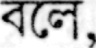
বলে,
